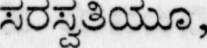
ಸರಸ್ವತಿಯೂ,
